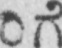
ರಿಗೆ
